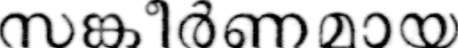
സങ്കീര്‍ണമായ
